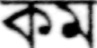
কম
